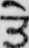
ਤੇ
